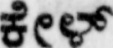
ಕೇಳ್
